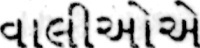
વાલીઓએ
